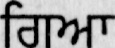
ਗਿਆ
